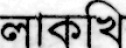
লাকখি
